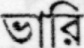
ভারি
